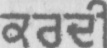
ਕਰਦੀ
